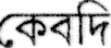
কেবদি
